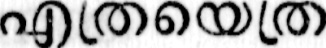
എത്രയെത്ര
